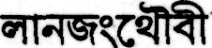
লানজংথৌবী
